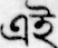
এই
